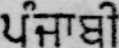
ਪੰਜਾਬੀ
